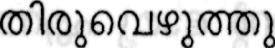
തിരുവെഴുത്തു
